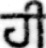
ਹੀ
